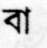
বা
